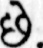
છે.
